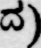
ದ)
